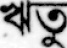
ঋতু
